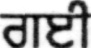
ਗਈ
